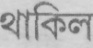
থাকিল
